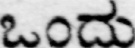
ಒಂದು
